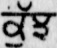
ਕੁੱਝ
